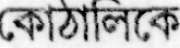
কোঠালিকে
